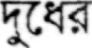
দুধের
